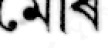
মোৰ
